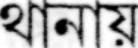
থানায়
